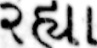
રહ્યા
